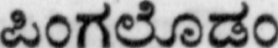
ಪಿಂಗಲೊಡಂ
